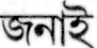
জনাই
